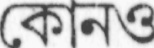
কোনও
